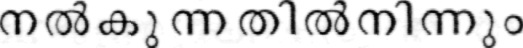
നല്‍കുന്നതില്‍നിന്നും
